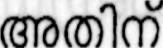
അതിന്
